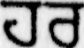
ਹਰ
